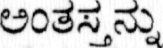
ಅಂತಸ್ತನ್ನು
